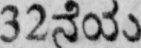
32ನೆಯ
